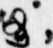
છતાં
